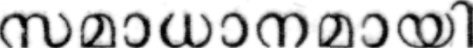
സമാധാനമായി
